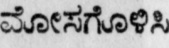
ಮೋಸಗೊಳಿಸಿ
